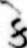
કે
